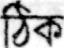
ঠিক
